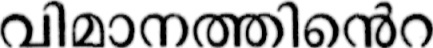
വിമാനത്തിന്റെ
